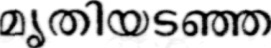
മൃതിയടഞ്ഞ
